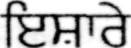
ਇਸ਼ਾਰੇ
